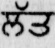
ਲੱਤ
